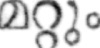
മറ്റും
